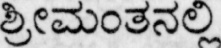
ಶ್ರೀಮಂತನಲ್ಲಿ
